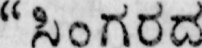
“ಸಿಂಗರದ
